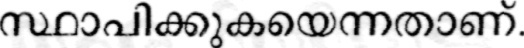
സ്ഥാപിക്കുകയെന്നതാണ്.
